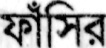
ফাঁসির
